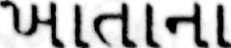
ખાતાના
